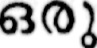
ഒരു
